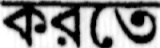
করতে
